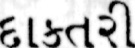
દાક્તરી
